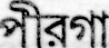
পীরগা
